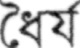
ধৈর্য
